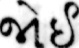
જોઈ
